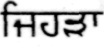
ਜਿਹੜਾ
